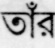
তাঁর
